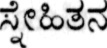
ಸ್ನೇಹಿತನ
